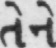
તેને
